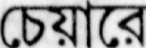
চেয়ারে
